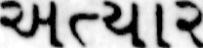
અત્યાર
